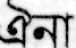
ঐনা
